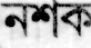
নশক
